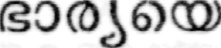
ഭാര്യയെ
